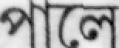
পালে
